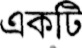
একটি
